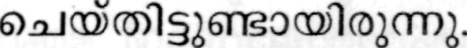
ചെയ്തിട്ടുണ്ടായിരുന്നു.
